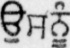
ਉਸਨੂੰ
